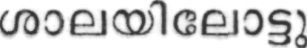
ശാലയിലോട്ടു
